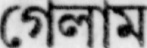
গেলাম
